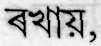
ৰখায়,
